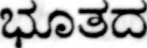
ಭೂತದ
